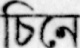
চিনে
